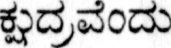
ಕ್ಷುದ್ರವೆಂದು
